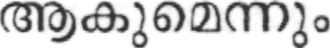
ആകുമെന്നും
